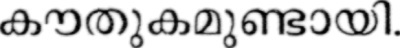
കൌതുകമുണ്ടായി.
